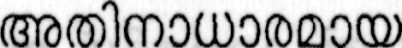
അതിനാധാരമായ
